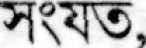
সংযত,
